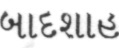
બાદશાહ
